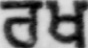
ਰਖ
